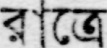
রাত্রে
